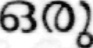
ഒരു
